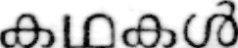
കഥകള്‍
